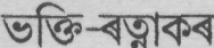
ভক্তি-ৰত্নাকৰ
